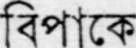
বিপাকে
